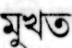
মুখত
